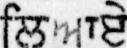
ਲਿਆਏ
